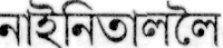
নাইনিতাললৈ
